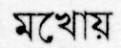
মখোয়
